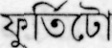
ফুর্তিটো
